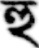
হু
